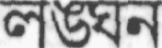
লঙ্ঘন
